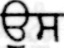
ਉਸ
